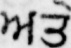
ਅਤੇ
